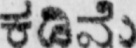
ಕಡಿಮೆ
